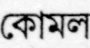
কোমল
